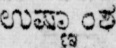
ಉಷ್ಣಾಂಶ
